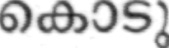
കൊടു
